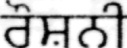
ਰੌਸ਼ਨੀ
